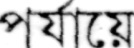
পর্যায়ে
